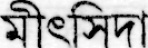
মীৎসিদা
